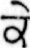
ਕੇ
